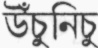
উঁচুনিচু
